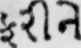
ફરીને
